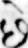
છે
